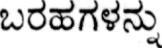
ಬರಹಗಳನ್ನು
